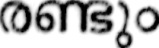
രണ്ടും
